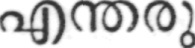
എന്തരു
